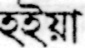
হইয়া
